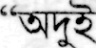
“অদুই
